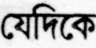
যেদিকে
